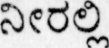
ನೀರಲ್ಲಿ
